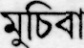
মুচিবা
